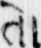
તો
